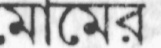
মোমের
